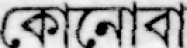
কোনোবা
